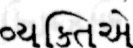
વ્યક્તિએ
